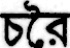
চরৈ
